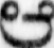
ಆ
